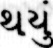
થયું
